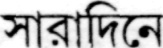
সারাদিনে
